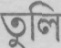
তুলি
